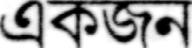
একজন
